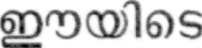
ഈയിടെ
